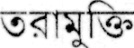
তরামুক্তি
